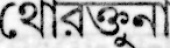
থোরক্তুনা
